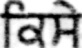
ਕਿਸੇ
